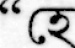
“হে
